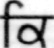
ਕਿ
